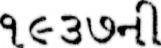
૧૯૩૭ની
